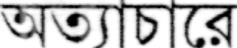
অত্যাচারে
